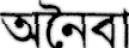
অনৈবা
